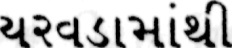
યરવડામાંથી
